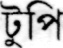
টুপি
